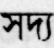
সদ্য
